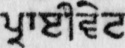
ਪ੍ਰਾਈਵੇਟ
